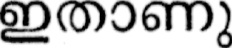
ഇതാണു
